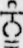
ਨੂੰ
